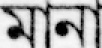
মানা
